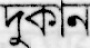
দুকান
